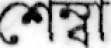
শেম্বা
